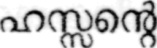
ഹസ്സന്റെ
